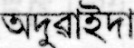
অদুৱাইদা
